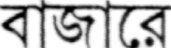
বাজারে
